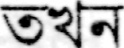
তখন
